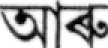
আৰু
